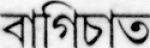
বাগিচাত
